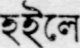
হইলে
